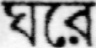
ঘরে
